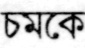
চমকে
